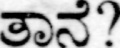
ತಾನೆ?
